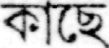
কাছে
